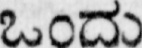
ಒಂದು
